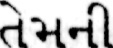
તેમની
